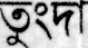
তুংদা
